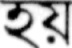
হয়
